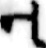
ન
